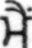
ਮੈਂ
